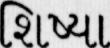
શિષ્યા
